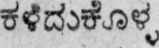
ಕಳೆದುಕೊಳ್ಳ
